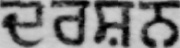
ਦਰਸ਼ਨ
